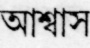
আশ্বাস
